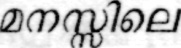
മനസ്സിലെ
